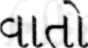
વાતો
